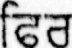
ਫਿਰ
